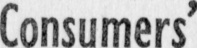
Consumers’
